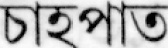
চাহপাত
